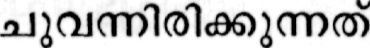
ചുവന്നിരിക്കുന്നത്
